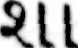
શા
